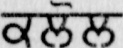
ਕਲੋਲ
